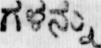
ಗಳನ್ನು
